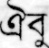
ঐবু
